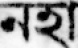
নহা
